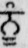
ਨੂੰ
